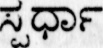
ಸ್ಪರ್ಧಾ
